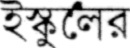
ইস্কুলের
